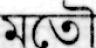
মতৌ
